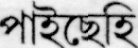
পাইছেহি
